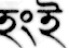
হংই
